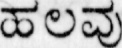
ಹಲವು
